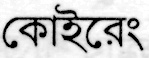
কোইরেং
